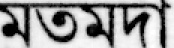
মতমদা
